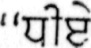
''ਧੀਏ
